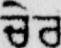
ਚੇਰ
